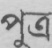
পুত্ৰ
